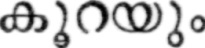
കൂറയും
